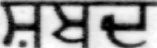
ਸ਼ਬਦ
